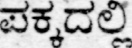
ಪಕ್ಕದಲ್ಲಿ
